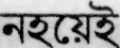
নহয়েই
